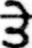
ਤੇ
